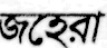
জহেরা
